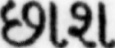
છાશ
